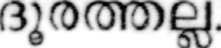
ദൂരത്തല്ല.
